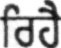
ਰਿਹੈ
